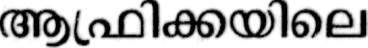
ആഫ്രിക്കയിലെ
